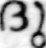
ദു
